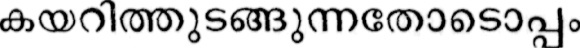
കയറിത്തുടങ്ങുന്നതോടൊപ്പം
